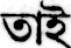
তাই
